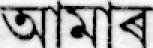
আমাৰ
